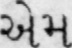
એમ
